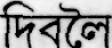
দিবলৈ
